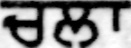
ਚਲਾ
